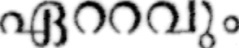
ഏററവും
